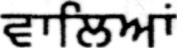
ਵਾਲਿਆਂ
